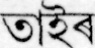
তাইৰ
